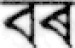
বৰ
